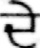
ਦੇ
